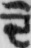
ਦੋ
